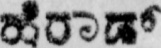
ಹೆರಾಡ್
